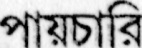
পায়চারি
